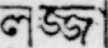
লজ্জা
